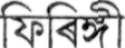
ফিৰিঙ্গী
